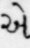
એ
